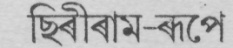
ছিৰীৰাম-ৰূপে
